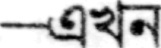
-এখন
